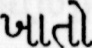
ખાતો
